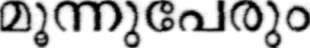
മൂന്നുപേരും
